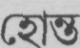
হোন্ত
